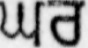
ਘਰ
